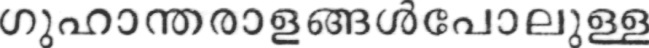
ഗുഹാന്തരാളങ്ങള്‍പോലുള്ള
